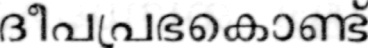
ദീപപ്രഭകൊണ്ട്
